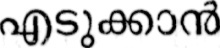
എടുക്കാന്‍
